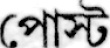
পোস্ট
